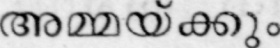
അമ്മയ്ക്കും
